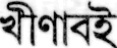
খীণাবই
